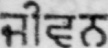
ਜੀਵਨ
